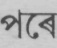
পৰে
